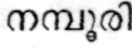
നമ്പൂരി
